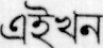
এইখন
